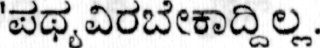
‘ಪಥ್ಯವಿರಬೇಕಾದ್ದಿಲ್ಲ.
